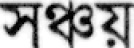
সঞ্চয়
